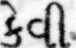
કેવી
